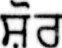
ਸ਼ੋਰ
